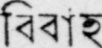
বিবাহ
